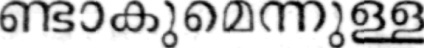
ണ്ടാകുമെന്നുള്ള
